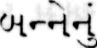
બન્નેનું
